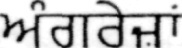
ਅੰਗੇਰਜ਼ਾਂ
